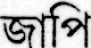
জাপি
